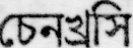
চেনখ্রসি
